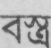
বস্ত্ৰ
